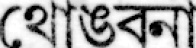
থোঙবনা
